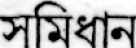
সমিধান
